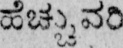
ಹೆಚ್ಚುವರಿ
